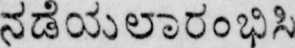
ನಡೆಯಲಾರಂಭಿಸಿ
